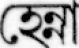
হেন্না
